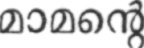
മാമന്റെ
